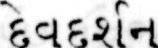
દેવદર્શન
